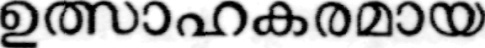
ഉത്സാഹകരമായ
